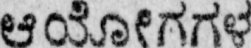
ಆಯೋಗಗಳ
